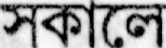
সকালে
